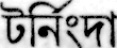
টর্নিংদা
